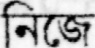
নিজে
